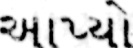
આપ્યો
